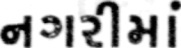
નગરીમાં
